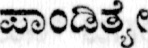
ಪಾಂಡಿತ್ಯೇ
